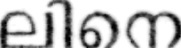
ലിനെ
